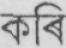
কৰি
